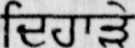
ਦਿਹਾੜੇ
